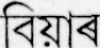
বিয়াৰ
